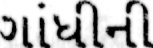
ગાંધીની
